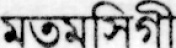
মতমসিগী
